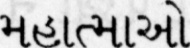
મહાત્માઓ
